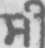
ਸੀ
